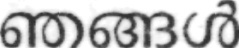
ഞങ്ങള്‍
